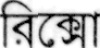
রিক্সো
